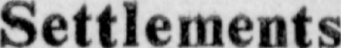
Settlements
